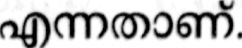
എന്നതാണ്.
